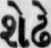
શેઢે
